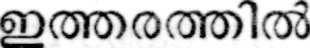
ഇത്തരത്തില്‍
